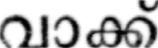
വാക്ക്
